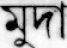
মুদা
